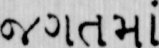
જગતમાં
